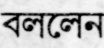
বললেন
